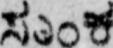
ಸುಂಕ
